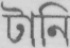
টানি
